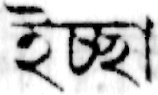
ইচ্ছা
